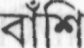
বাঁশি
